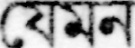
যেমন
